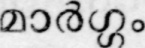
മാര്‍ഗ്ഗം
